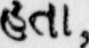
હતા,
